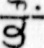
ਭੌਂ
